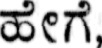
ಹೇಗೆ,
